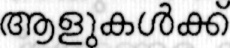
ആളുകള്‍ക്ക്
